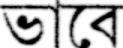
ভাবে
